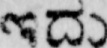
ಇದು
